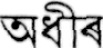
অধীৰ
